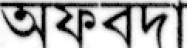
অফবদা
